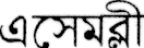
এসেমব্লী
